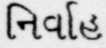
નિર્વાહ
